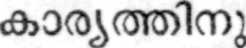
കാര്യത്തിനു
